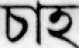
চাহ
